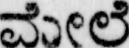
ಮೇಲೆ
